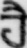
ਹੈ
